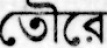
তৌরে
